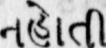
નહોતી
